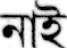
নাই
